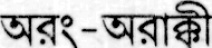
অরং-অরাক্কী
